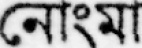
নোংমা
